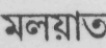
মলয়াত
